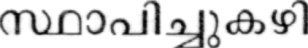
സ്ഥാപിച്ചുകഴി
